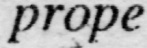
prope
